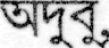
অদুবু,
